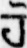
ਹੋ
